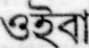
ওইবা
